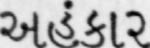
અહંકાર
